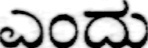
ತಂದು
